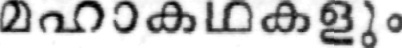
മഹാകഥകളും
